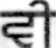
ਵੀ
